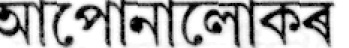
আপোনালোকৰ
